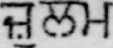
ਜ਼ੁਲਮ
